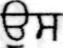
ਉਸ
